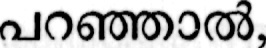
പറഞ്ഞാല്‍,
